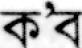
ক'ব
